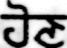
ਹੋਣ
